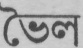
ভৈল
